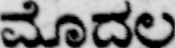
ಮೊದಲ
